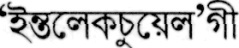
‘ইন্তলেকচুয়েল’গী
